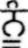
ਨੂੰ
